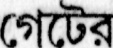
গেটের
